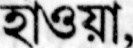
হাওয়া,
